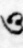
ও
